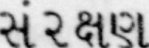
સંરક્ષણ
